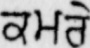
ਕਮਰੇ
